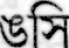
ঙসি
